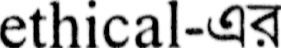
ethical-এর
